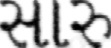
સારુ
